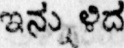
ಇನ್ನುಳಿದ
